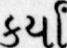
કર્યાં
